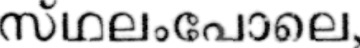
സ്ഥലംപോലെ,
